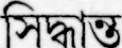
সিদ্ধান্ত
